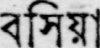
বসিয়া
